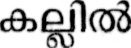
കല്ലില്‍
